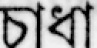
চাধা
